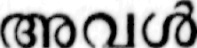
അവള്‍
